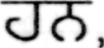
ਹਨ,
